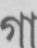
গা
